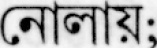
নোলায়;
